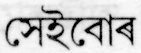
সেইবোৰ
